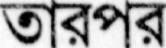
তারপর
